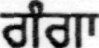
ਗੰਗਾ
